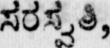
ಸರಸ್ವತಿ,
